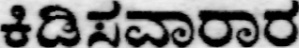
ಕಿಡಿಸವಾರಾರ
